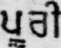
ਪੂਰੀ
